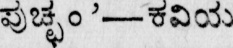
ಪುಚ್ಛಂ’-ಕವಿಯ
